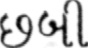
છબી
